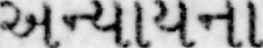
અન્યાયના
